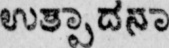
ಉತ್ಪಾದನಾ
